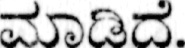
ಮಾಡಿದೆ.
